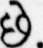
છે.
